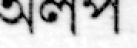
অলপ
